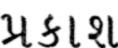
પ્રકાશ
